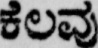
ಕೆಲವು
